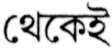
থেকেই
